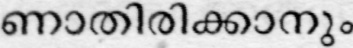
ണാതിരിക്കാനും
